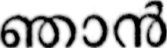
ഞാന്‍
